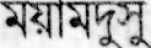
ময়ামদুসু
